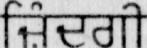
ਜ਼ਿੰਦਗੀ
